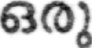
ഒരു
